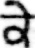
ਕੇ
